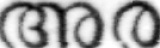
അര
